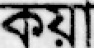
কয়া
